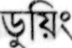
ডুয়িং
